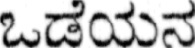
ಒಡೆಯನ
